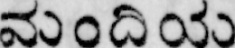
ಮಂದಿಯ
